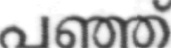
പഞ്ഞ്
